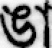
ঙা
